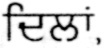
ਦਿਲਾਂ,
